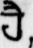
ਹੈ,
